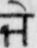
ਜੇ
